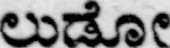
ಲುಡೋ
